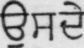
ਉਸਦੇ
